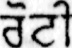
ਰੋਟੀ
